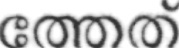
ത്തേത്
